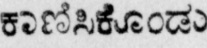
ಕಾಣಿಸಿಕೊಂಡು
